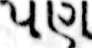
પણ
